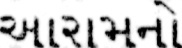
આરામનો
